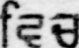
ਵਿਚ
